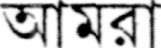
আমরা
